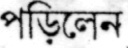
পড়িলেন
